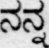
ನನ್ನ
